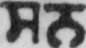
ਸਨ
